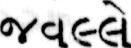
જવલ્લે
